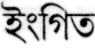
ইংগিত
